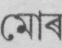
মোৰ
